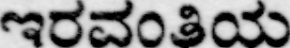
ಇರವಂತಿಯ
